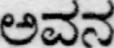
ಅವನ
